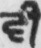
ਵੀ
